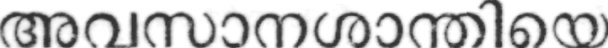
അവസാനശാന്തിയെ
